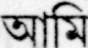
আমি
